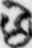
છે
